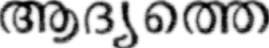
ആദ്യത്തെ
